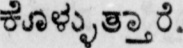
ಕೊಳ್ಳುತ್ತಾರೆ.
